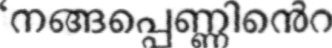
‘നങ്ങപ്പെണ്ണിന്റെ
